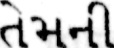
તેમની
